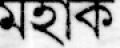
মহাক
